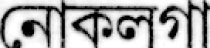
নোকলগা
